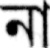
না
